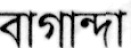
বাগান্দা
